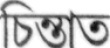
চিন্তাত
